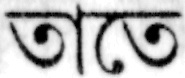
তাতে
